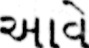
આવે
